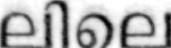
ലിലെ
